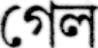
গেল
